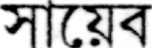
সায়েব
